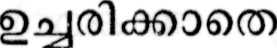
ഉച്ചരിക്കാതെ
